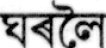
ঘৰলৈ
